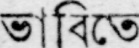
ভাবিতে
